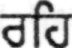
ਰਹਿ
